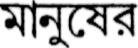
মানুষের
